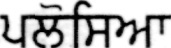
ਪਲੋਸਿਆ
